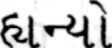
હ્યન્યો
